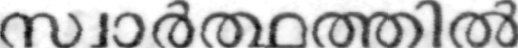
സ്വാര്‍ത്ഥത്തില്‍
